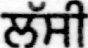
ਲੱਸੀ
